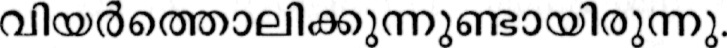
വിയര്‍ത്തൊലിക്കുന്നുണ്ടായിരുന്നു.
